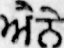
ਐਨੇ
